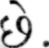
છે.
